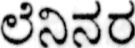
ಲೆನಿನರ
